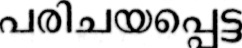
പരിചയപ്പെട്ട
